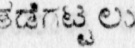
ತಡೆಗಟ್ಟಲು
